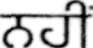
ਨਹੀਂ
